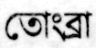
তোংব্রা
